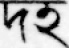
দহ
